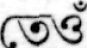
তেওঁ
